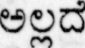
ಅಲ್ಲದೆ
